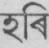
হৰি
